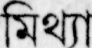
মিথ্যা
